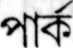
পার্ক
